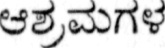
ಆಶ್ರಮಗಳ
